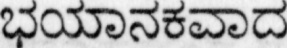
ಭಯಾನಕವಾದ
